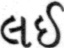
લઈ
